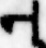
ન
